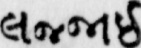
લજ્જાઈ
